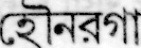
হৌনরগা
